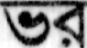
ভর
